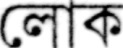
লোক
